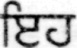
ਇਹ
